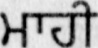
ਮਾਹੀ
